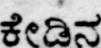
ಕೇಡಿನ
